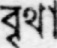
বৃথা
